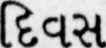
દિવસ
